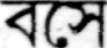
বসে
